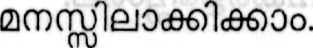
മനസ്സിലാക്കിക്കാം.
